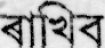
ৰাখিব
